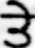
ਤੇ
